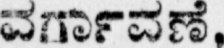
ವರ್ಗಾವಣೆ,
